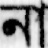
না
